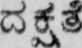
ದಕ್ಷತೆ
